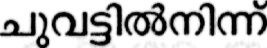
ചുവട്ടില്‍നിന്ന്
